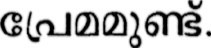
പ്രേമമുണ്ട്.
